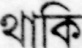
থাকি
